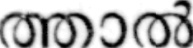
ത്താല്‍
